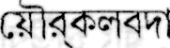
য়ৌরকলবদা
